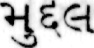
મુદ્દલ
